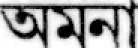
অমনা
